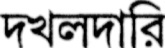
দখলদারি
